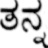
ತನ್ನ
